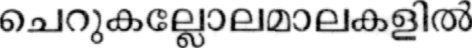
ചെറുകല്ലോലമാലകളില്‍
